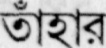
তাঁহার
